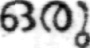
ഒരു
